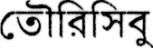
তৌরিসিবু
